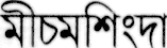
মীচমশিংদা
